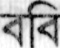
ববি
